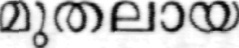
മുതലായ
